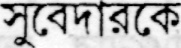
সুবেদারকে
